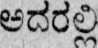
ಅದರಲ್ಲಿ
